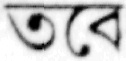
তবে
